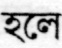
হলে
